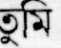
তুমি
